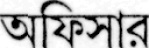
অফিসার
